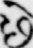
છે
